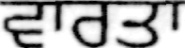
ਵਾਰਤਾ
